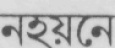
নহয়নে
